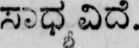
ಸಾಧ್ಯವಿದೆ.
